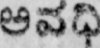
ಅವಧಿ
